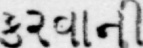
કરવાની
